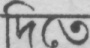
দিতে
